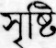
সৃষ্টি
